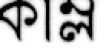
কাম্ল
